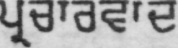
ਪ੍ਰਚਾਰਵਾਦ
